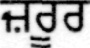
ਜ਼ਰੂਰ
